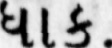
ધાક.
